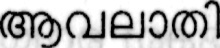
ആവലാതി
